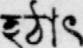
হঠাৎ
